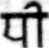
ਧੀ
